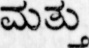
ಮತ್ತು
